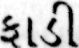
ફાડી
